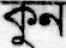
কুন
